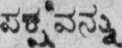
ಪಕ್ಷವನ್ನು
